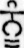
ਨੂੰ
